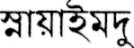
স্নায়াইমদু
